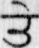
ਤੇ
